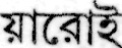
য়ারোই
